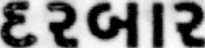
દરબાર
